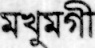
মখুমগী
